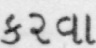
કરવા
